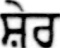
ਸ਼ੇਰ
